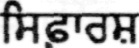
ਸਿਫ਼ਾਰਸ਼
